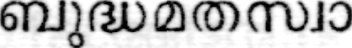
ബുദ്ധമതസ്വാ
